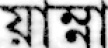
য়াম্না
